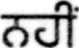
ਨਹੀਂ
